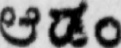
ಆಡಂ
